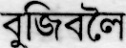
বুজিবলৈ
